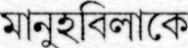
মানুহবিলাকে
